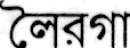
লৈরগা
